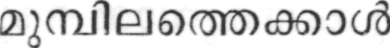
മുമ്പിലത്തെക്കാള്‍
